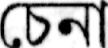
চেনা
